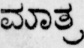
ಮಾತ್ರ
